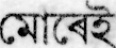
মোৰেই
